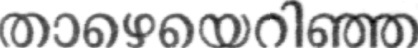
താഴെയെറിഞ്ഞ
